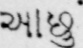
આછું
